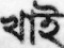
খাই
